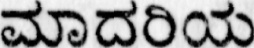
ಮಾದರಿಯ
